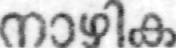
നാഴിക
